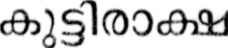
കുട്ടിരാക്ഷ
